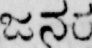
ಜನರ
